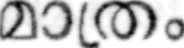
മാത്രം
